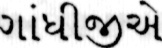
ગાંધીજીએ
